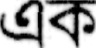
এক
